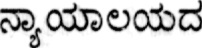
ನ್ಯಾಯಾಲಯದ
